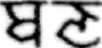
ਬਣ
